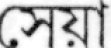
সেয়া
